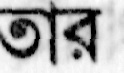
তার
